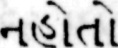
નહોતો
